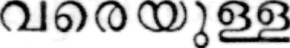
വരെയുള്ള
